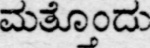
ಮತ್ತೊಂದು
